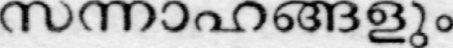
സന്നാഹങ്ങളും
